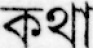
কথা
